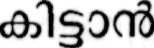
കിട്ടാന്‍
